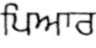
ਪਿਆਰ
